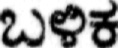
ಬಳಿಕ
